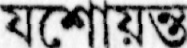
যশোয়ন্ত
